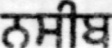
ਨਸੀਬ
